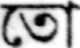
তো
